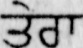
ਤੇਰਾ
